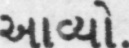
આવ્યો.
